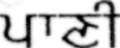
ਪਾਣੀ
